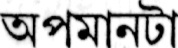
অপমানটা
